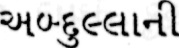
અબ્દુલ્લાની
